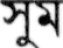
সুম
